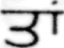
ਤਾਂ
